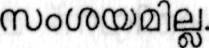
സംശയമില്ല.
